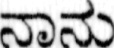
ನಾನು
